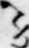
કે
